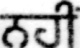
ਨਹੀਂ
